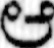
ಆ
